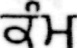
ਕੰਮ
